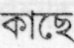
কাছে
